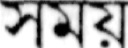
সময়
